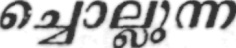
ച്ചൊല്ലുന്ന
